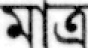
মাত্র
